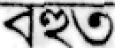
বহুত
